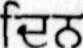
ਦਿਨ
